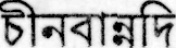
চীনবান্নদি
